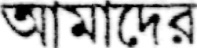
আমাদের
